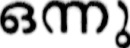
ഒന്നു
